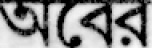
অবের
